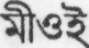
মীওই
